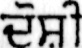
ਦੋਸ਼ੀ
